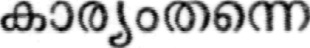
കാര്യംതന്നെ
